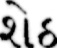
શેઠ
